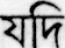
যদি
